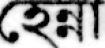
হেন্না
